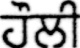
ਹੋਲੀ
